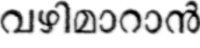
വഴിമാറാന്‍
